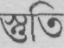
স্তুতি
